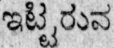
ಇಟ್ಟಿರುವ
